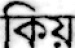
কিয়
